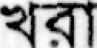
খরা
